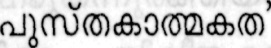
പുസ്തകാത്മകത'
